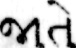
જાતે
